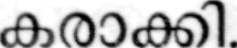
കരാക്കി.
